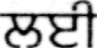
ਲਈ
